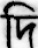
দি
